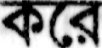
করে
